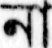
না
